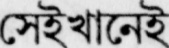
সেইখানেই
